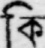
কি
